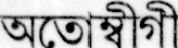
অতোম্বীগী
